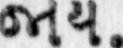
જાય.
